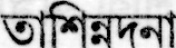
তাশিন্নদনা
